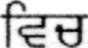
ਵਿਚ
